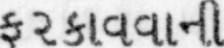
ફરકાવવાની
